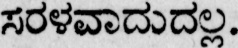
ಸರಳವಾದುದಲ್ಲ.
